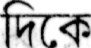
দিকে
